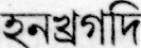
হনখ্রগদি
